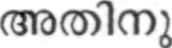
അതിനു
